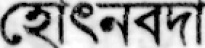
হোৎনবদা
